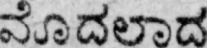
ಮೊದಲಾದ
